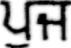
ਪੁਜ
